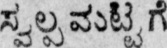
ಸ್ವಲ್ಪಮಟ್ಟಿಗೆ
